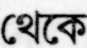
থেকে
